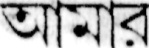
আমার
